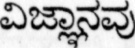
ವಿಜ್ಞಾನವು
